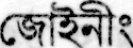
জোইনীং
